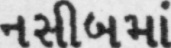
નસીબમાં
